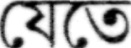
যেতে
